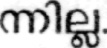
ന്നില്ല.
